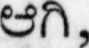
ಆಗಿ,
